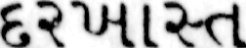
દરખાસ્ત
